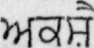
ਅਕਸ਼ੈ
